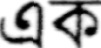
এক
